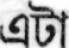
এটা
